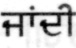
ਜਾਂਦੀ
